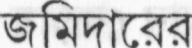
জমিদারের
